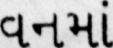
વનમાં
